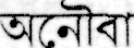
অনৌবা
